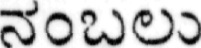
ನಂಬಲು
